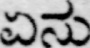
ಏನು
